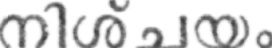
നിശ്ചയം
